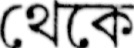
থেকে
